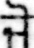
ਜੋ
